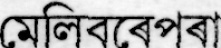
মেলিবৰেপৰা
